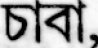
চাবা,
